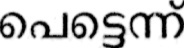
പെട്ടെന്ന്
